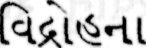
વિદ્રોહના
